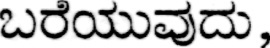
ಬರೆಯುವುದು,
